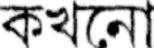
কখনো
